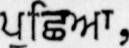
ਪੁਛਿਆ,
